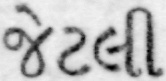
જેટલી
